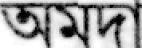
অমদা
